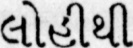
લોહીથી
